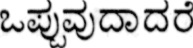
ಒಪ್ಪುವುದಾದರೆ
